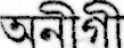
অনীগী
